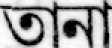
তানা
